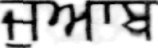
ਜੁਆਬ
